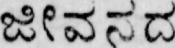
ಜೀವನದ
